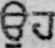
ਉਹ
